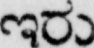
ಇರು
